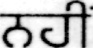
ਨਹੀਂ
